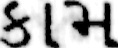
કામ
